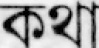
কথা
